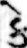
કે
